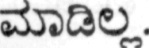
ಮಾಡಿಲ್ಲ.
